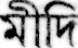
মীদি
